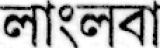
লাংলবা
